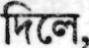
দিলে,
